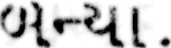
બન્યા.
